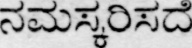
ನಮಸ್ಕರಿಸದೆ
